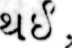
થઈ,
